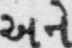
અને
